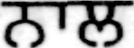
ਨਾਲ
